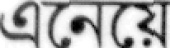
এনেয়ে
